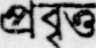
প্রবৃত্ত
